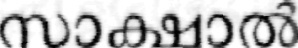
സാക്ഷാല്‍
